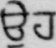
ਉਹ
